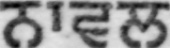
ਨਾਵਲ
